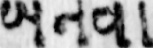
બનવા
